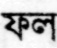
ফল
